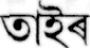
তাইৰ
